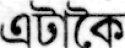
এটাকৈ
